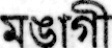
মঙাগী
